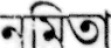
নমিতা
